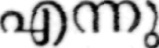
എന്നു
